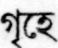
গৃহে
